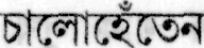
চালোহেঁতেন
